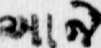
આજે
